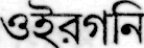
ওইরগনি
